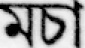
মচা
